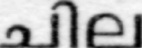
ചില
